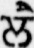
ਲੈ
